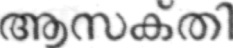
ആസക്തി
